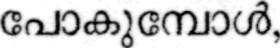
പോകുമ്പോള്‍,
